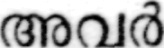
അവര്‍
